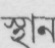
স্থান
